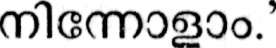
നിന്നോളാം.'
